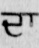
ਦਾ
